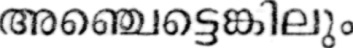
അഞ്ചെട്ടെങ്കിലും
